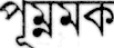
পূম্নমক
